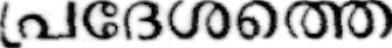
പ്രദേശത്തെ
